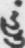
હું
